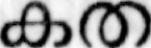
കത
